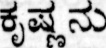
ಕೃಷ್ಣನು
